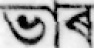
ভাৰ
